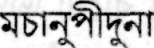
মচানুপীদুনা
